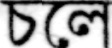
চলে
